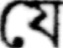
যে
